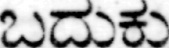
ಬದುಕು
